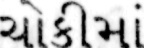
ચોકીમાં
